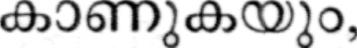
കാണുകയും,
